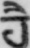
ਹੈ
